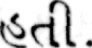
હતી.
